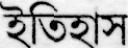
ইতিহাস
